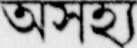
অসহ্য
